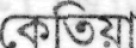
কেতিয়া
